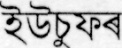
ইউচুফৰ
